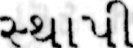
સ્થાપી
